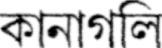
কানাগলি
